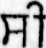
ਸੀ
